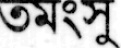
তমংসু
